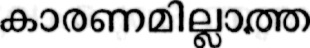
കാരണമില്ലാത്ത
